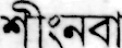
শীংনবা
